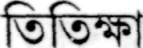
তিতিক্ষা
